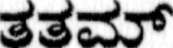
ತತಮ್
